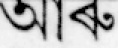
আৰু
